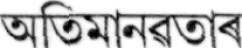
অতিমানৱতাৰ
